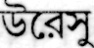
উরেসু
